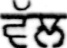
ਵੱਲ
